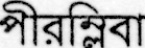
পীরম্লিবা
